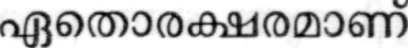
ഏതൊരക്ഷരമാണ്
